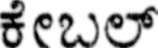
ಕೇಬಲ್
